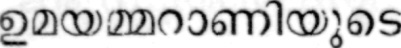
ഉമയമ്മറാണിയുടെ
